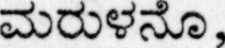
ಮರುಳನೊ,
